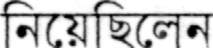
নিয়েছিলেন
